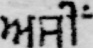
ਅਸੀਂ
